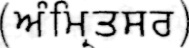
(ਅੰਮ੍ਰਿਤਸਰ)
